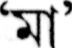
‘মা’
